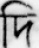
দি
